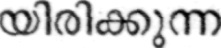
യിരിക്കുന്ന
